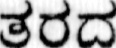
ತರದ
